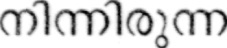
നിന്നിരുന്ന
